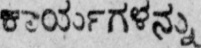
ಕಾರ್ಯಗಳನ್ನು
